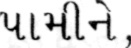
પામીને,
